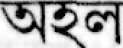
অহল
